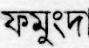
ফমুংদা
